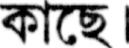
কাছে।
